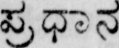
ಪ್ರಧಾನ
